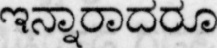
ಇನ್ನಾರಾದರೂ
